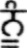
ਨੂੰ
